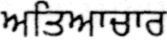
ਅਤਿਆਚਾਰ
